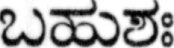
ಬಹುಶಃ
